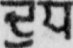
ਦੁਧ
